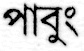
পাবুং
